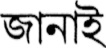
জানাই
